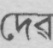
দেৱ
